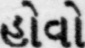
હોવો
